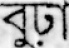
বুঢ়া
